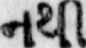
નથી
